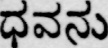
ಧವನು
